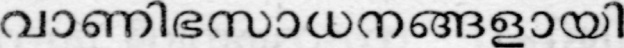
വാണിഭസാധനങ്ങളുമായി
